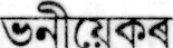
ভনীয়েকৰ
